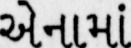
એનામાં
